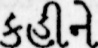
કહીને
